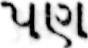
પણ
